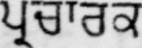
ਪ੍ਰਚਾਰਕ
